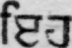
ਇਹ
